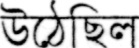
উঠেছিল
